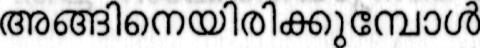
അങ്ങിനെയിരിക്കുമ്പോള്‍
